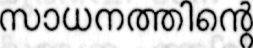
സാധനത്തിന്റെ
